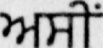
ਅਸੀਂ
